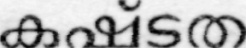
കഷ്ടത
